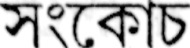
সংকোচ
